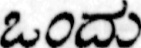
ಒಂದು
